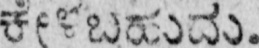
ಕೇಳಬಹುದು.
